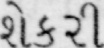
શેકરી
